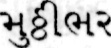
મુઠ્ઠીભર
